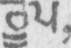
ਰੂਪ,
